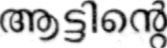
ആട്ടിന്റെ
